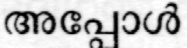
അപ്പോള്‍
